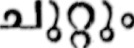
ചുറ്റും
